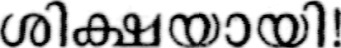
ശിക്ഷയായി!
